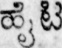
ಹೈಟಿ
